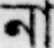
না
